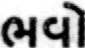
ભવો
